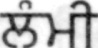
ਲੰਮੀ
